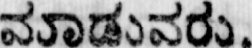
ಮಾಡುವರು.
